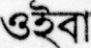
ওইবা
